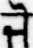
ਜੋ
